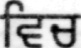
ਵਿਚ
